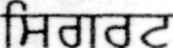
ਸਿਗਰਟ
